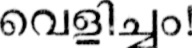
വെളിച്ചം!
